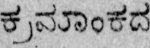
ಕ್ರಮಾಂಕದ
